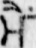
ਮੈਂ
